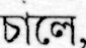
চালে,
